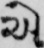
એ
